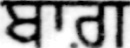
ਬਾਗ਼
